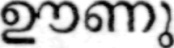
ഊണു
